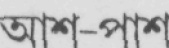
আশ-পাশ
